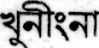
খুনীংনা
